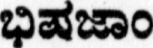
ಭಿಷಜಾ೦
